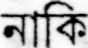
নাকি
